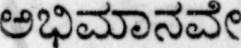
ಅಭಿಮಾನವೇ
